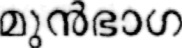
മുന്‍ഭാഗ
